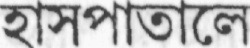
হাসপাতালে
